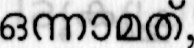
ഒന്നാമത്,
